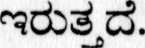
ಇರುತ್ತದೆ.
